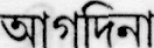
আগদিনা
